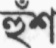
হুঁশ
